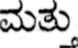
ಮತ್ತು
